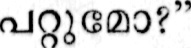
പറ്റുമോ?”
